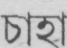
চাহা
